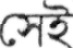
সেই
